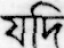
যদি
